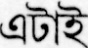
এটাই
